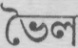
ভৈল
